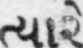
ત્યારે
